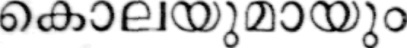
കൊലയുമായും
